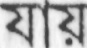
যায়
